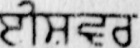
ਈਸ਼ਵਰ
